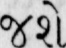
જશે
